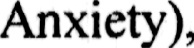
Anxiety),
